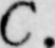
C.
